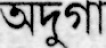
অদুগা
